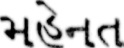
મહેનત
